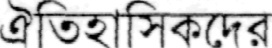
ঐতিহাসিকদের
